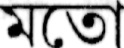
মতো
